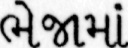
ભેજામાં
